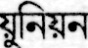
য়ুনিয়ন
